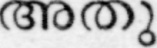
അതു
